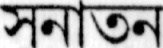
সনাতন
